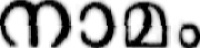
നാമം
